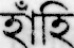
হাঁহি
